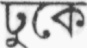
ঢুকে
